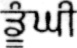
ਡੂੰਘੀ
